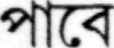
পাবে
